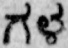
ಗಳ
